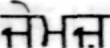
ਜੇਮਜ਼
